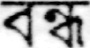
বন্ধ
